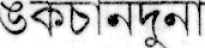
ঙকচানদুনা
